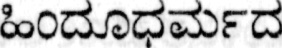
ಹಿಂದೂಧರ್ಮದ
